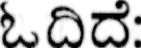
ಓದಿದೆ:
